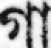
গা
